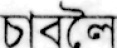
চাবলৈ
